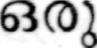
ഒരു
